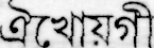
ঐখোয়গী
